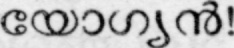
യോഗ്യന്‍!
